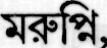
মরুপ্নি,
